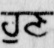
ਹੁਣ
